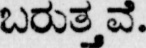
ಬರುತ್ತವೆ.
